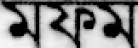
মফম
